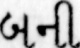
બની
